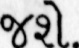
જશે.
